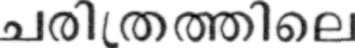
ചരിത്രത്തിലെ
